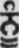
ਨੂੰ
